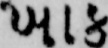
ખાક
